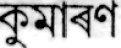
কুমাৰণ
